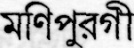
মণিপুরগী
